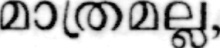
മാത്രമല്ല,
